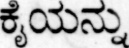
ಕೈಯನ್ನು
